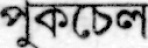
পুকচেল
